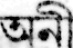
অনী
